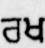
ਰਖ
